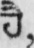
ਹੈ,
